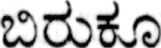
ಬಿರುಕೂ
